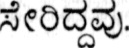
ಸೇರಿದ್ದವು.
